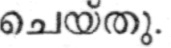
ചെയ്തു.
